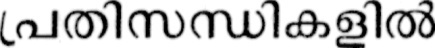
പ്രതിസന്ധികളില്‍
